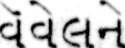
વૅવેલને
